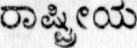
ರಾಷ್ಟ್ರೀಯ
